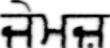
ਜੇਮਜ਼
